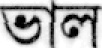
ভাল
